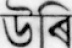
উৰি
